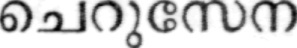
ചെറുസേന
